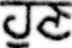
ਹੁਣ
